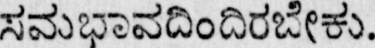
ಸಮಭಾವದಿಂದಿರಬೇಕು.
